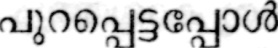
പുറപ്പെട്ടപ്പോള്‍
